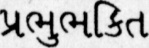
પ્રભુભક્તિ
